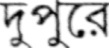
দুপুরে
